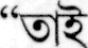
"তাই
